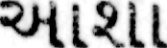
આશા
